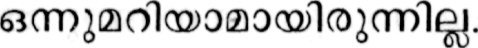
ഒന്നുമറിയാമായിരുന്നില്ല.
